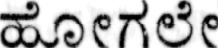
ಹೋಗಲೇ
